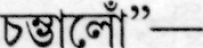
চম্ভালোঁ"-
